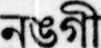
নঙগী
